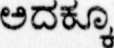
ಅದಕ್ಕೂ
